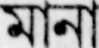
মানা
